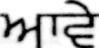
ਆਵੇ
